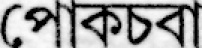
পোকচবা
